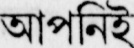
আপনিই
